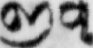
જીવ
